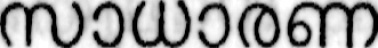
സാധാരണ
